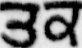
ਤਕ
